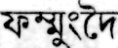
ফম্মুংদৈ
